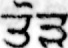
ਤੋੜ
